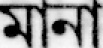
মানা
